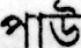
পাউ
